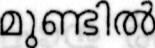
മുണ്ടില്‍
